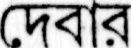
দেবার
